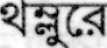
থম্লুরে
